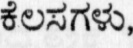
ಕೆಲಸಗಳು,
